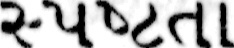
સ્પષ્ટતા
